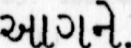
આગને.
